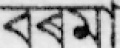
বৰমা
